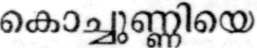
കൊച്ചുണ്ണിയെ
